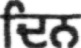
ਦਿਨ
